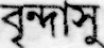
বৃন্দাসু
